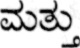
ಮತ್ತು
